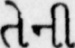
તેની
